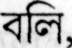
বলি,
